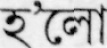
হ'লো
